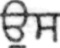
ਉਸ
